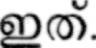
ഇത്.
